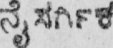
ನೈಸರ್ಗಿಕ
